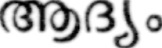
ആദ്യം
